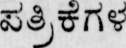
ಪತ್ರಿಕೆಗಳ
